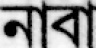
নাবা
